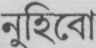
নুহিবো
